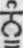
ਨੂੰ
